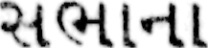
સભાના
